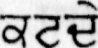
ਕਟਦੇ
